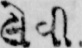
લેવી.
